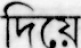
দিয়ে
